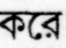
করে
